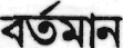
বৰ্তমান
